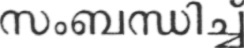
സംബന്ധിച്ച്
